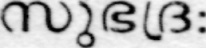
സുഭദ്ര:
